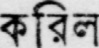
করিল
